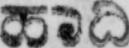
ಹಾದಿ
